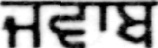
ਜਵਾਬ
